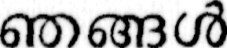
ഞങ്ങള്‍
